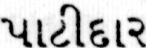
પાટીદાર
